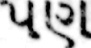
પણ
